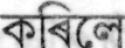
কৰিলে
